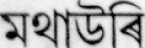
মথাউৰি
